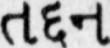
તદ્દન
